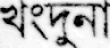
খংদুনা
